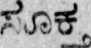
ಸೂಕ್ತ
